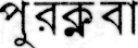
পুরক্নবা
